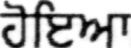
ਹੋਇਆ
